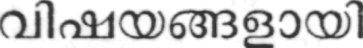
വിഷയങ്ങളായി
